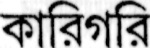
কারিগরি
